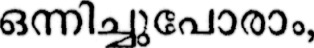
ഒന്നിച്ചുപോരാം,
